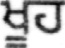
ਖੂਹ
